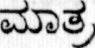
ಮಾತ್ರ
